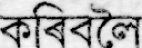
কৰিবলৈ
